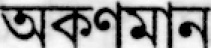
অকণমান
